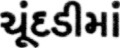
ચૂંદડીમાં
